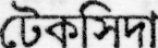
টেকসিদা
